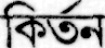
কির্তন
